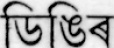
ডিঙিৰ
